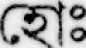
হোঃ
